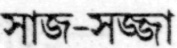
সাজ-সজ্জা
